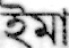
ইমা
